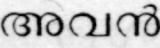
അവന്‍
